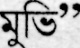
মুভি”
